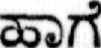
ಹಾಗೆ
